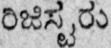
ರಿಜಿಸ್ಟರು
